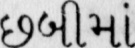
છબીમાં
